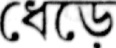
ধেড়ে
